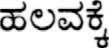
ಹಲವಕ್ಕೆ
